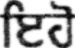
ਇਹੋ
